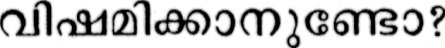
വിഷമിക്കാനുണ്ടോ?
